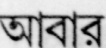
আবার
